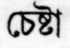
চেষ্টা
